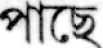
পাছে
